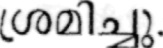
ശ്രമിച്ചു.
